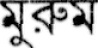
মুরুম
